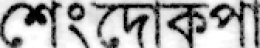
শেংদোকপা
